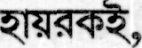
হায়রকই,
